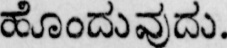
ಹೊಂದುವುದು.
